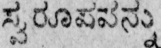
ಸ್ವರೂಪವನ್ನು
